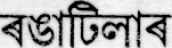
ৰঙাটিলাৰ
